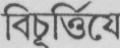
বিচূৰ্ত্তিযে
